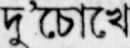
দু'চোখে
